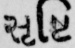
સૃષ્ટિ
